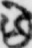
છે
